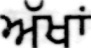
ਅੱਖਾਂ
